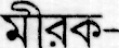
মীরক-
